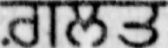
ਗ਼ਲਤ
